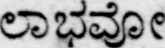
ಲಾಭವೋ
